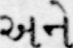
અને
